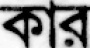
কার
